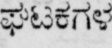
ಘಟಕಗಳ
